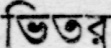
ভিতর
